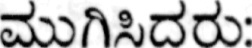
ಮುಗಿಸಿದರು:
